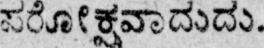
ಪರೋಕ್ಷವಾದುದು.
